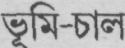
ভূমি-চাল
